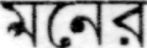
মনের
